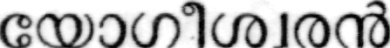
യോഗീശ്വരന്‍
